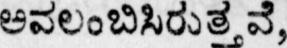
ಅವಲಂಬಿಸಿರುತ್ತವೆ,
